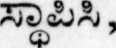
ಸ್ಥಾಪಿಸಿ,
